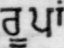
ਰੂਪਾਂ
